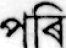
পৰি
